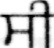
ਸੀ
